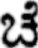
ಚೆ
